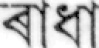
ৰাধা
